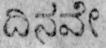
ದಿನವೇ
